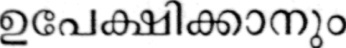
ഉപേക്ഷിക്കാനും
